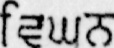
ਵਿਘਨ
